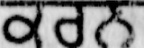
ਕਰਨ
